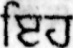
ਇਹ
